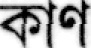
কাণ
